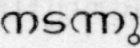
നടന്നു
